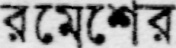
রমেশের
